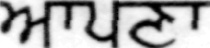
ਆਪਣਾ
